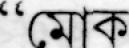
"মোক
